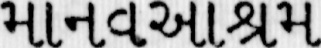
માનવઆશ્રમ
